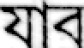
যাব
